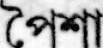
পৈশা
